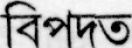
বিপদত
